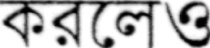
করলেও
